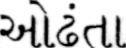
ઓઢંતા
